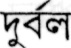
দুর্বল
